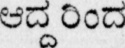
ಆದ್ದರಿಂದ
